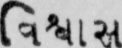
વિશ્વાસ
